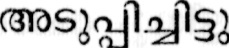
അടുപ്പിച്ചിട്ടു
